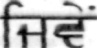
ਜਿਵੇਂ
